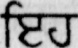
ਇਹ
